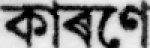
কাৰণে
